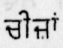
ਚੀਜ਼ਾਂ
